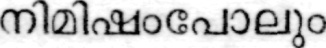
നിമിഷംപോലും
